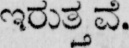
ಇರುತ್ತವೆ.
